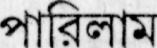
পারিলাম
